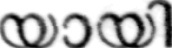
യായി
